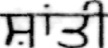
ਸ਼ਾਂਤੀ
